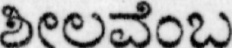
ಶೀಲವೆಂಬ
